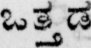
ಒತ್ತಡ
